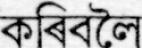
কৰিবলৈ
